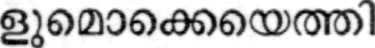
ളുമൊക്കെയെത്തി
